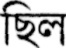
ছিল
